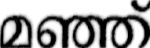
മഞ്ഞ്
